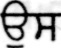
ਉਸ
